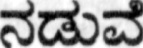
ನಡುವೆ
